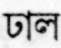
ঢাল
